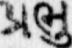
પ્રભુ
